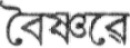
বৈষ্ণৱে
